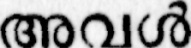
അവള്‍
